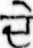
ਦੇ
